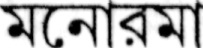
মনোরমা
